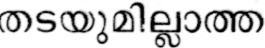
തടയുമില്ലാത്ത
